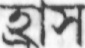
হ্রাস
